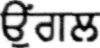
ਉਂਗਲ
